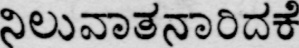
ನಿಲುವಾತನಾರಿದಕೆ
